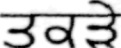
ਤਕੜੇ
